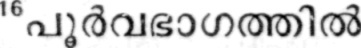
16പൂര്‍വഭാഗത്തില്‍
